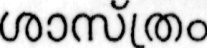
ശാസ്ത്രം
